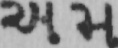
અમ
